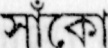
সাঁকো
